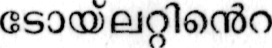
ടോയ്ലറ്റിന്റെ
